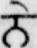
ਨੇ
